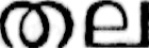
തല
